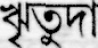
ঋৃতুদা
